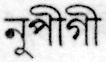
নুপীগী
